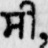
ਸੀ,
